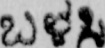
ಬಳಸಿ
